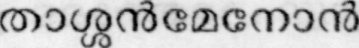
താശ്ശന്‍മേനോന്‍
